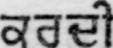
ਕਰਦੀ
